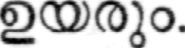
ഉയരും.
